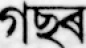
গছৰ
